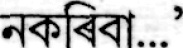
নকৰিবা...'
